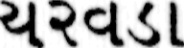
યરવડા
